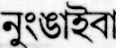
নুংঙাইবা
